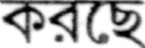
করছে
